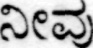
ನೀವು
